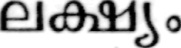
ലക്ഷ്യം
